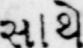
સાથે
